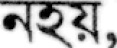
নহয়,
